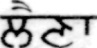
ਲੈਣਾ
